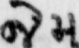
જેમ
